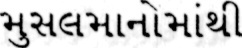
મુસલમાનોમાંથી
